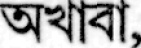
অখাবা,
